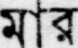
মার
